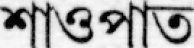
শাওপাত
